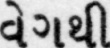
વેગથી
